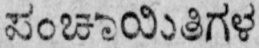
ಪಂಚಾಯಿತಿಗಳ
